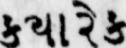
ક્યારેક
